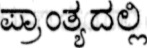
ಪ್ರಾಂತ್ಯದಲ್ಲಿ
